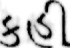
કહી
